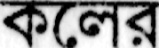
কলের
